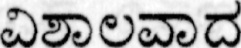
ವಿಶಾಲವಾದ
